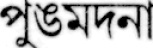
পুঙমদনা
